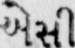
બેસી
